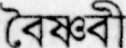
বৈষ্ণবী
